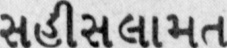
સહીસલામત
